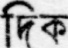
দিক
